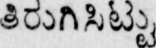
ತಿರುಗಿಸಿಟ್ಟು
